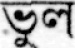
ভুল
